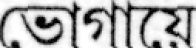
ভোগায়ে
